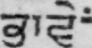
ਭਾਵੇਂ
